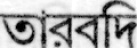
তারবদি
